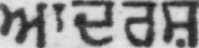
ਆਦਰਸ਼
